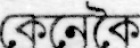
কেনেকৈ
